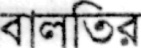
বালতির
